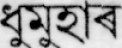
ধুমুহাৰ
